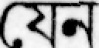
যেন
